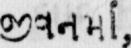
જીવનમાં,
